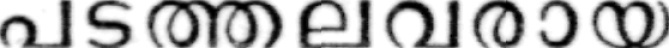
പടത്തലവരായ
